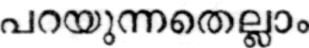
പറയുന്നതെല്ലാം
